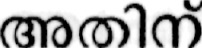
അതിന്
